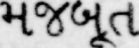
મજબૂત
